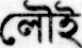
লৌই
